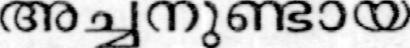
അച്ചനുണ്ടായ
